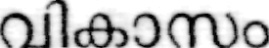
വികാസം
